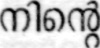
നിന്റെ
